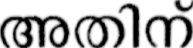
അതിന്
